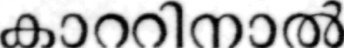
കാററിനാല്‍
